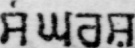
ਸੰਘਰਸ਼
